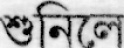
শুনিলে
